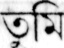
তুমি
